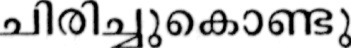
ചിരിച്ചുകൊണ്ടു
